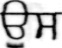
ਉਸ
